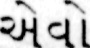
એવો
